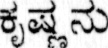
ಕೃಷ್ಣನು
